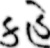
કહે
